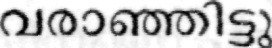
വരാഞ്ഞിട്ടു
